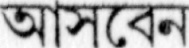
আসবেন
